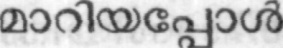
മാറിയപ്പോള്‍
